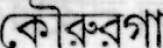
কৌরুরগা
